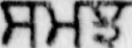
ਸਮਝ
